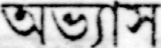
অভ্যাস
